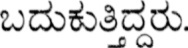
ಬದುಕುತ್ತಿದ್ದರು.
